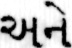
અને
